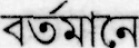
বর্তমানে
